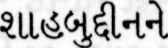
શાહબુદ્દીનને
